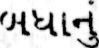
બધાનું
